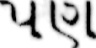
પણ
